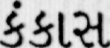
કંકાસ
